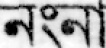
নংনা
